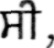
ਸੀ,
